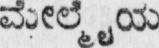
ಮೇಲ್ಮೈಯ
